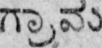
ಗ್ರಾಮ
